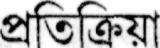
প্রতিক্রিয়া
